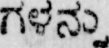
ಗಳನ್ನು
